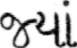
જ્યાં
